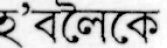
হ'বলৈকে
